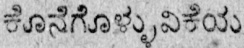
ಕೊನೆಗೊಳ್ಳುವಿಕೆಯ
